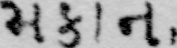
મકાન
